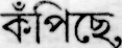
কঁপিছে,
